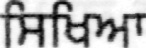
ਸਿਖਿਆ
